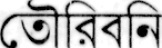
তৌরিবনি
